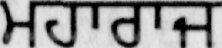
ਮਹਾਰਾਜ
